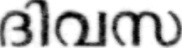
ദിവസ
